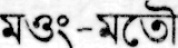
মওং-মতৌ
